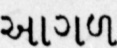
આગળ
